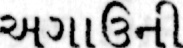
અગાઉની
